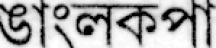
ঙাংলকপা
